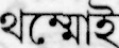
থম্মোই
